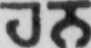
ਹਨ
